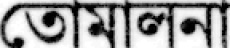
তোমালনা
